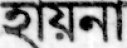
হায়না
